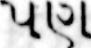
પણ
